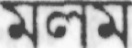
মলম
